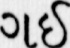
ગઈ
